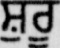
ਸ਼ੁਰੂ
